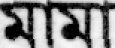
মামা
